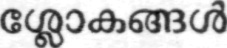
ശ്ലോകങ്ങള്‍
